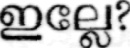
ഇല്ലേ?
